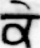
ਕੇ
